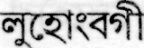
লুহোংবগী
